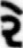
રે
